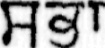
ਸਭਾ
